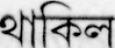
থাকিল
